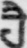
ਹੈ
